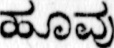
ಹೂವು
